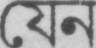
যেন
